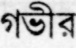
গভীর
